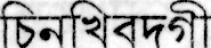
চিনখিবদগী
